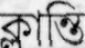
ক্লান্তি
